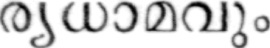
ര്യധാമവും
